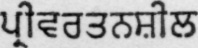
ਪ੍ਰੀਵਰਤਨਸ਼ੀਲ
